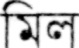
মিল
